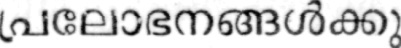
പ്രലോഭനങ്ങള്‍ക്കു
